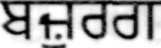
ਬਜ਼ੁਰਗ
